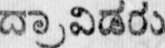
ದ್ರಾವಿಡರು
